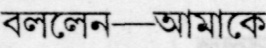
বললেন–আমাকে
